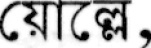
য়োল্লে,
